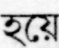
হয়ে
